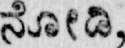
ನೋಡಿ,
